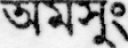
অমসুং
